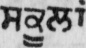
ਸਕੂਲਾਂ
